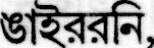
ঙাইররনি
